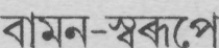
বামন-স্বৰূপে
